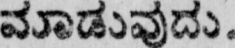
ಮಾಡುವುದು.
